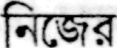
নিজের
